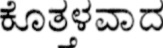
ಕೊತ್ತಳವಾದ
